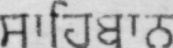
ਸਾਹਿਬਾਨ
